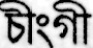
চীংগী
